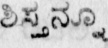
ಶಿಸ್ತನ್ನೂ
